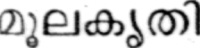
മൂലകൃതി
